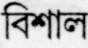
বিশাল
